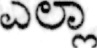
ಎಲ್ಲಾ
